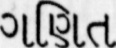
ગણિત
